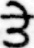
ਤੇ
